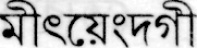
মীৎয়েংদগী
